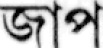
জাপ
